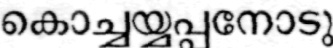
കൊച്ചയ്യപ്പനോടു
